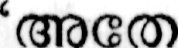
'അതേ
